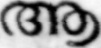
ആ
